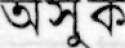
অসুক
